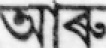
আৰু
